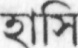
হাসি
